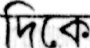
দিকে
